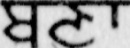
ਬਣਾ
